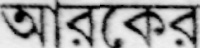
আরকের
